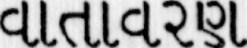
વાતાવરણ
